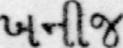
ખનીજ
